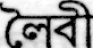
লৈবী
